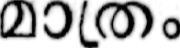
മാത്രം
